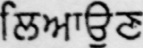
ਲਿਆਉਣ
